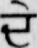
ਦੇ
